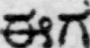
ಈಗ
